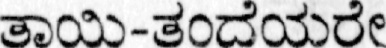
ತಾಯಿ-ತಂದೆಯರೇ
